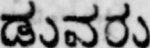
ಡುವರು
